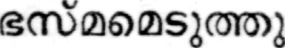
ഭസ്മമെടുത്തു
